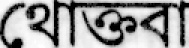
থোক্তবা
